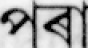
পৰা
